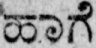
ಹಾಗೆ
